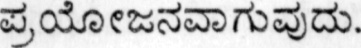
ಪ್ರಯೋಜನವಾಗುವುದು.
